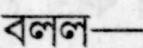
বলল–
